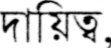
দায়িত্ব,
